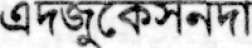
এদজুকেসনদা
